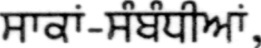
ਸਾਕਾਂ-ਸੰਬੰਧੀਆਂ,
